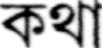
কথা
